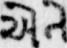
એને
